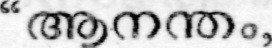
"ആനന്തം,
